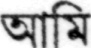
আমি
